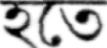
হতে
